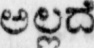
ಅಲ್ಲದೆ
